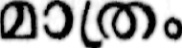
മാത്രം
